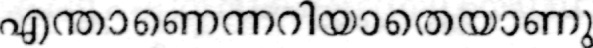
എന്താണെന്നറിയാതെയാണു
